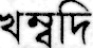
খম্বদি
